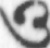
ও
